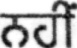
ਨਹੀਂ
